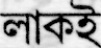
লাকই
